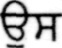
ਉਸ
